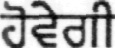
ਹੋਵੇਗੀ
